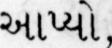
આપ્યો,
